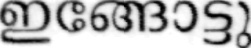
ഇങ്ങോട്ടു
